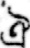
ঐ
